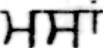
ਮਸਾਂ
